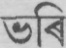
ভৰি
